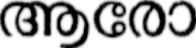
ആരോ
